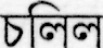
চলিল
